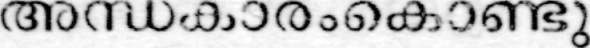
അന്ധകാരംകൊണ്ടു
